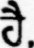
ਹੈ,
